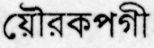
য়ৌরকপগী
